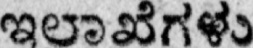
ಇಲಾಖೆಗಳು
